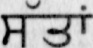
ਸੱਤਾਂ
